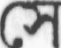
সে
